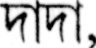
দাদা,
